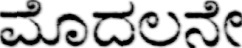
ಮೊದಲನೇ
